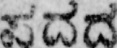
ಪದದ
